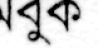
মবুক
